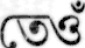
তেওঁ
